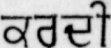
ਕਰਦੀ
